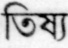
তিষ্য
